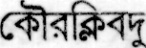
কৌরক্লিবদু
